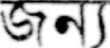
জন্য
